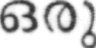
ഒരു
